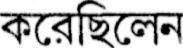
করেছিলেন
